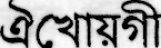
ঐখোয়গী
